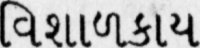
વિશાળકાય
